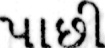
પાછી
